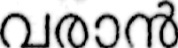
വരാന്‍
